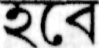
হবে
